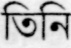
তিনি
